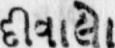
દીવાલો
